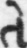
તે
